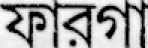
ফারগা
